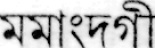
মমাংদগী
